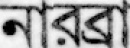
নারব্রা
